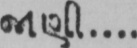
જાણી....
